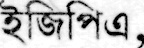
ইজিপিএ,
